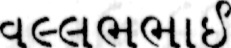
વલ્લભભાઈ
